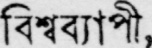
বিশ্বব্যাপী,
